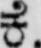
ಕೆ.
